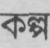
কল্প
